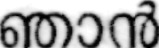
ഞാന്‍
